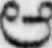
ಆ
